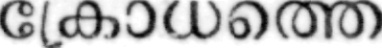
ക്രോധത്തെ
